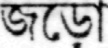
জড়ো
